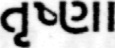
તૃષ્ણા
